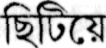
ছিটিয়ে
